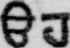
ਉਹ
